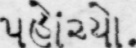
પહોંચ્યો.
